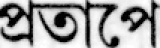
প্রতাপে
